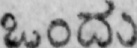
ಒಂದು
